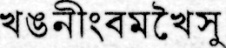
খঙনীংবমখৈসু
